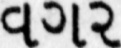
વગર
